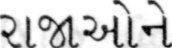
રાજાઓને
